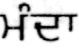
ਮੰਦਾ
